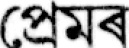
প্রেমৰ
